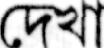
দেখা
